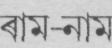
ৰাম-নাম
